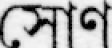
সোণ
